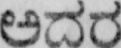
ಅದರ
